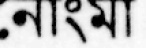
নোংমা
